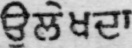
ਉਲੇਖਦਾ
